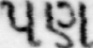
પણ
